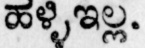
ಹಳ್ಳಿಇಲ್ಲ.
